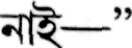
নাই-"
